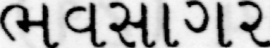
ભવસાગર
